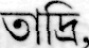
তাদ্রি,
